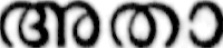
അതാ
